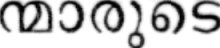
ന്മാരുടെ
